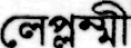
লেপ্লম্মী
